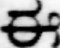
ಈ
